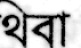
থিবা
